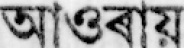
আওৰায়
